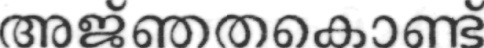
അജ്ഞതകൊണ്ട്
